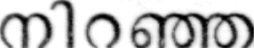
നിറഞ്ഞ
